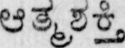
ಆತ್ಮಶಕ್ತಿ
